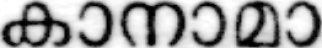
കാനാമാ
